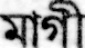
মাগী
